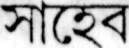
সাহেব
